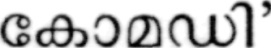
കോമഡി'
